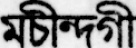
মচীন্দগী
